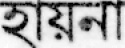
হায়না
